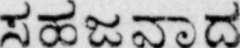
ಸಹಜವಾದ
